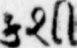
કશી
